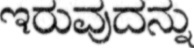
ಇರುವುದನ್ನು
